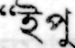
“ইপু
